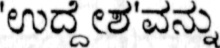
‘ಉದ್ದೇಶ’ವನ್ನು
